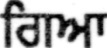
ਗਿਆ
